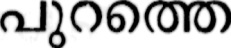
പുറത്തെ
